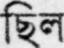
ছিল
